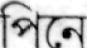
পিনে
